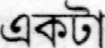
একটা
